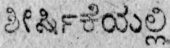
ಶೀರ್ಷಿಕೆಯಲ್ಲಿ
